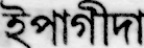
ইপাগীদা
